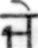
ਜੇ
